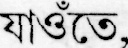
যাওঁতে,
